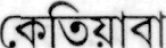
কেতিয়াবা
